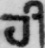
ਹੀ
